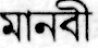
মানবী
